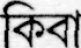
কিবা
